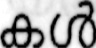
കള്‍
